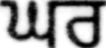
ਘਰ
